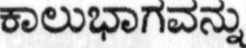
ಕಾಲುಭಾಗವನ್ನು
